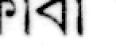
ফাবা
